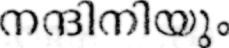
നന്ദിനിയും
